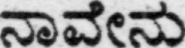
ನಾವೇನು
